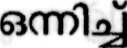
ഒന്നിച്ച്
